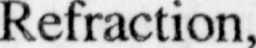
Refraction,
